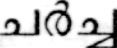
ചര്‍ച്ച
